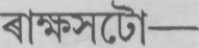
ৰাক্ষসটো-
